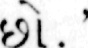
છો.'
